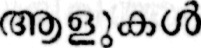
ആളുകള്‍
